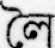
লৈ
